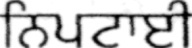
ਨਿਪਟਾਈ
